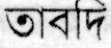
তাবদি
